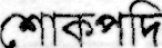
শোকপদি
